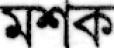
মশক
